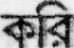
করি
